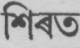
শিৰত
